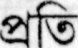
প্রতি
